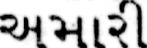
અમારી
